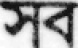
সব
